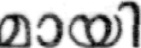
മായി
